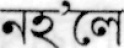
নহ'লে
